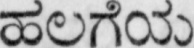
ಹಲಗೆಯ
